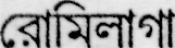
রোমিলাগা
